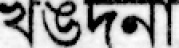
খঙদনা
